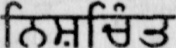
ਨਿਸ਼ਚਿੰਤ
